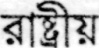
রাষ্ট্রীয়
